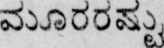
ಮೂರರಷ್ಟು
